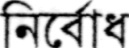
নির্বোধ
